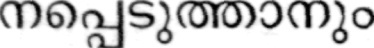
നപ്പെടുത്താനും
